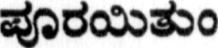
ಪೂರಯಿತುಂ
